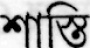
শাস্তি
